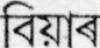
বিয়াৰ
